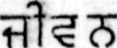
ਜੀਵਨ
